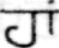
ਹਾਂ
